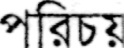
পরিচয়
